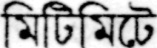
মিটিমিটে
